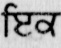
ਇਕ
